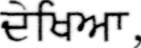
ਦੇਖਿਆ,
